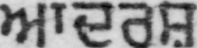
ਆਦਰਸ਼
